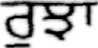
ਰੁਝਾ
